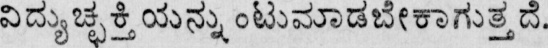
ವಿದ್ಯುಚ್ಛಕ್ತಿಯನ್ನುಂಟುಮಾಡಬೇಕಾಗುತ್ತದೆ.
